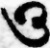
ও
